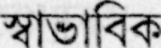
স্বাভাবিক
